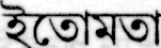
ইতোমতা
